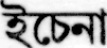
ইচেনা
